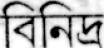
বিনিদ্র
